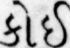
કોઈ
